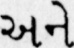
અને
